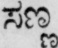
ಸಣ್ಣ
